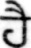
ਹੈ
